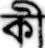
কী
